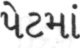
પેટમાં
